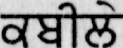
ਕਬੀਲੇ
